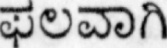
ಫಲವಾಗಿ
